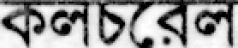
কলচরেল
